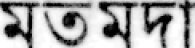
মতমদা
